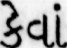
કેવાં
